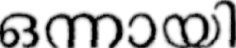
ഒന്നായി
